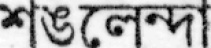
শঙলেন্দা
